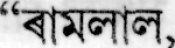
"ৰামলাল,
